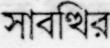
সাবত্থির
